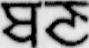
ਬਣ
